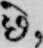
છે,
